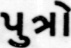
પુત્રો
